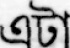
এটা
